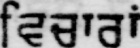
ਵਿਚਾਰਾਂ
